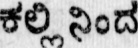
ಕಲ್ಲಿನಿಂದ
